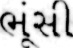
ભૂંસી
